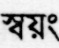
স্বয়ং
